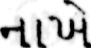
નાખે
